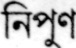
নিপুণ
